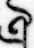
ঐ
